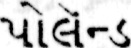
પોલૅન્ડ
